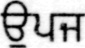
ਉਪਜ
